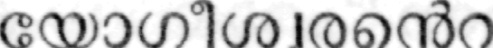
യോഗീശ്വരന്റെ
